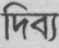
দিব্য
